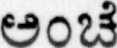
ಅಂಚೆ
